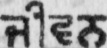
ਜੀਵਨ
